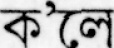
ক'লে
